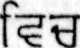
ਵਿਚ
